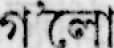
গ'লো
